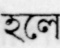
হলে
